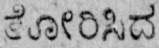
ತೋರಿಸಿದ
